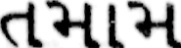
તમામ
